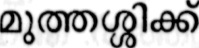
മുത്തശ്ശിക്ക്
